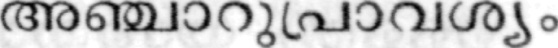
അഞ്ചാറുപ്രാവശ്യം
